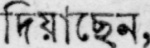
দিয়াছেন,
